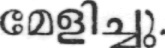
മേളിച്ചു.
